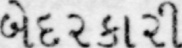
બેદરકારી
